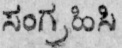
ಸಂಗ್ರಹಿಸಿ
